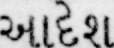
આદેશ
